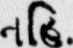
નહિ.
